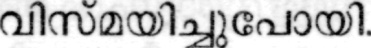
വിസ്മയിച്ചുപോയി.
